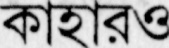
কাহারও
